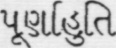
પૂર્ણહુતિ
